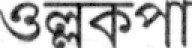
ওল্লকপা
